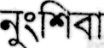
নুংশিবা
